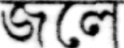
জলে
